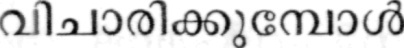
വിചാരിക്കുമ്പോള്‍
